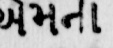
એમનો
